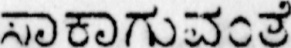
ಸಾಕಾಗುವಂತೆ
